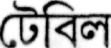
টেবিল
